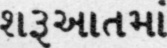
શરૂઆતમાં
